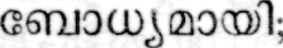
ബോധ്യമായി;
